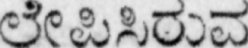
ಲೇಪಿಸಿರುವ
